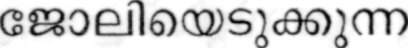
ജോലിയെടുക്കുന്ന
